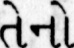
તેનો
